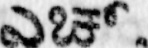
ಎಚ್.
